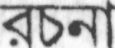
রচনা
